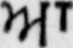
ਆ
